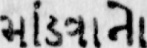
માંડવાનો
